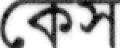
কেস
